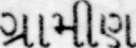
ગ્રામીણ
